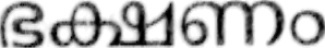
ഭക്ഷണം
